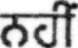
ਨਹੀਂ
